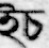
ইচ
